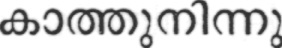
കാത്തുനിന്നു
